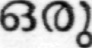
ഒരു
